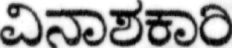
ವಿನಾಶಕಾರಿ
